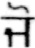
ਜੋ
